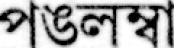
পঙলম্বা
